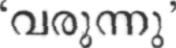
‘വരുന്നു'
